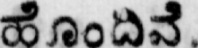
ಹೊಂದಿವೆ.
